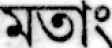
মতাং
